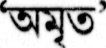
‘অমৃত’
